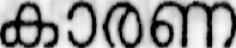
കാരണ
